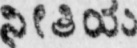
ನೀತಿಯ
